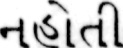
નહોતી
